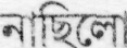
নাছিলো
